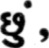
છું,
